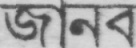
জানব
